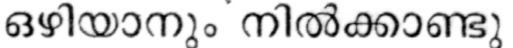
ഒഴിയാനുംനില്‍ക്കാണ്ടു
